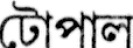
টোপাল
